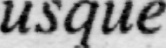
usque
